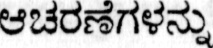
ಆಚರಣೆಗಳನ್ನು
